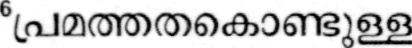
6പ്രമത്തതകൊണ്ടുള്ള
